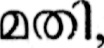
മതി,
